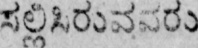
ಸಲ್ಲಿಸಿರುವವರು
